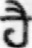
ਹੈ
